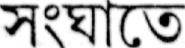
সংঘাতে
